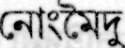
নোংমৈদু
